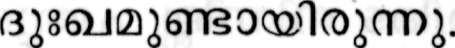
ദുഃഖമുണ്ടായിരുന്നു.
